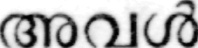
അവള്‍
